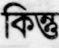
কিন্তু
